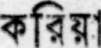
করিয়া
